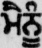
ਮੈਨੂੰ
